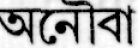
অনৌবা
